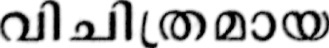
വിചിത്രമായ
